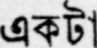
একটা
